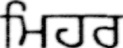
ਮਿਹਰ
